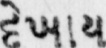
દેખાય
